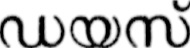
ഡയസ്
